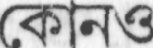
কোনও
